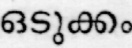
ഒടുക്കം
